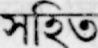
সহিত
